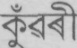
কুঁৱৰী
